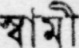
স্বামী
